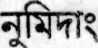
নুমিদাং
